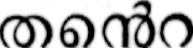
തന്റെ
